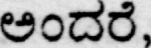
ಅಂದರೆ,
